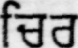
ਚਿਰ
